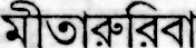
মীতারুরিবা
